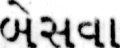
બેસવા
